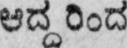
ಆದ್ದರಿಂದ
